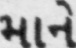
માને
